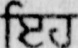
ਇਹ
